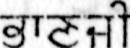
ਭਾਣਜੀ
